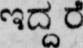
ಇದ್ದರೆ
